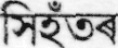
সিহঁতৰ
